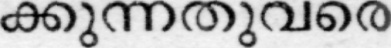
ക്കുന്നതുവരെ
